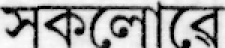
সকলোৱে
